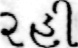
રહી
